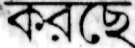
করছে
